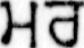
ਮਰ
